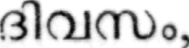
ദിവസം,
